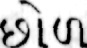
છોળ
